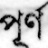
পূর্ণ
